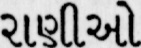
રાણીઓ
